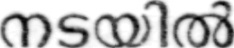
നടയില്‍
